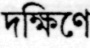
দক্ষিণে
